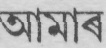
আমাৰ
